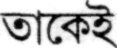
তাকেই
